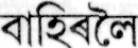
বাহিৰলৈ
